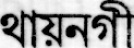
থায়নগী
